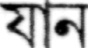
যান
